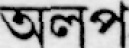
অলপ
